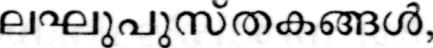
ലഘുപുസ്തകങ്ങള്‍,
